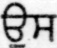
ਉਸ
